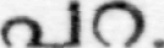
പറ.
